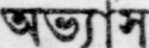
অভ্যাস
